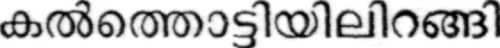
കല്‍ത്തൊട്ടിയിലിറങ്ങി
